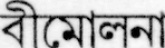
বীমোলনা
